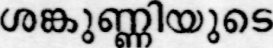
ശങ്കുണ്ണിയുടെ
